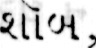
શૉબ,
